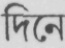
দিনে
